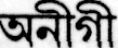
অনীগী
